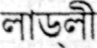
লাড্‌লী
